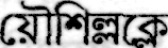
য়ৌশিল্লক্লে
